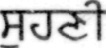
ਸੁਹਣੀ
